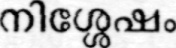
നിശ്ശേഷം
